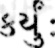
કર્યું:
